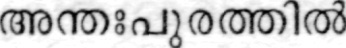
അന്തഃപുരത്തില്‍
